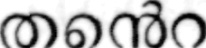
തന്റെ
